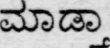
ಮಾಡ್ತಾ
